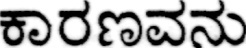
ಕಾರಣವನು
